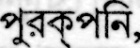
পুরক্পনি,
